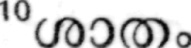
10ശാതം
